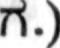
ಗ.)
